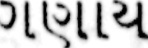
ગણાય
